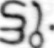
ട്ടു.
